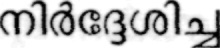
നിര്‍ദ്ദേശിച്ച
